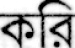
করি
